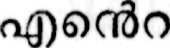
എന്റെ
